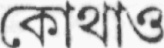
কোথাও
